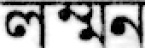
লম্মন
